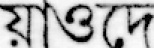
য়াওদে
